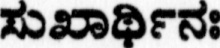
ಸುಖಾರ್ಥಿನಃ
